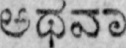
ಅಥವಾ
